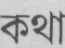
কথা
